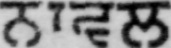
ਨਾਵਲ
